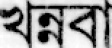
খন্নবা
